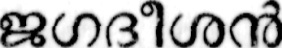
ജഗദീശന്‍
